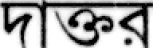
দাক্তর
